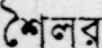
শৈলর
